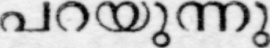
പറയുന്നു
